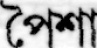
পৈশা
